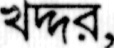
খদ্দর,
